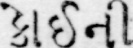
કોઈની
